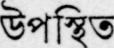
উপস্থিত
